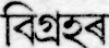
বিগ্ৰহৰ
